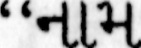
"નામ
